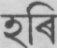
হৰি
